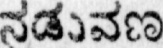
ನಡುವಣ
